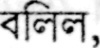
বলিল,
